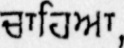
ਚਾਹਿਆ,
